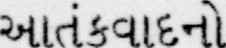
આતંકવાદનો
